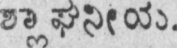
ಶ್ಲಾಘನೀಯ.
